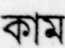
কাম
